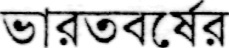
ভারতবর্ষের
